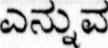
ಎನ್ನುವ
